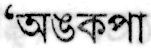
‘অঙকপা
